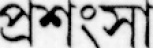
প্রশংসা
